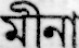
মীনা
